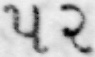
પર
